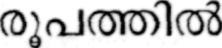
രൂപത്തില്‍
